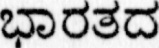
ಭಾರತದ
